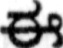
ಈ
